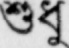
শুধু
